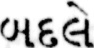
બદલે
